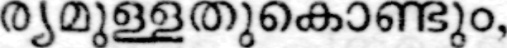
ര്യമുള്ളതുകൊണ്ടും,
